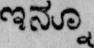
ಇನ್ನೂ
